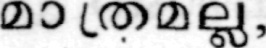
മാത്രമല്ല,
